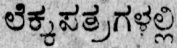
ಲೆಕ್ಕಪತ್ರಗಳಲ್ಲಿ
